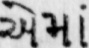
એમાં
